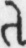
તે
